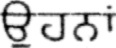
ਉਹਨਾਂ
